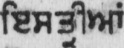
ਇਸਤ੍ਰੀਆਂ
